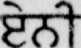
ਏਨੀ
